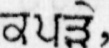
ਕਪੜੇ,
